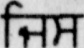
ਜਿਸ
